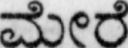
ಮೇರೆ
